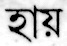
হায়
